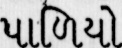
પાળિયો
